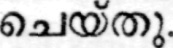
ചെയ്തു.
